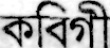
কবিগী
